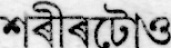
শৰীৰটোও
